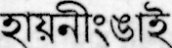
হায়নীংঙাই
